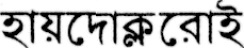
হায়দোক্লরোই
